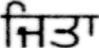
ਜਿਤਾ
